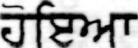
ਹੋਇਆ
